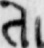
તો
